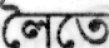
লৈতে
